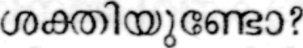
ശക്തിയുണ്ടോ?
